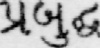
પ્રબુદ્ધ
